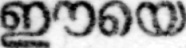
ഈയെ
